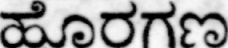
ಹೊರಗಣ
